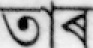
তাৰ
